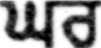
ਘਰ
